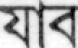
যাব
